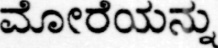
ಮೋರೆಯನ್ನು
